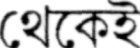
থেকেই
